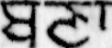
ਬਣਾ
